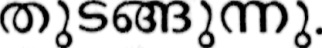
തുടങ്ങുന്നു.
